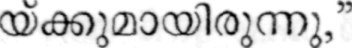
യ്ക്കുമായിരുന്നു,"
